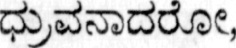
ಧ್ರುವನಾದರೋ,
